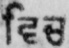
ਵਿਚ
